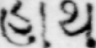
હાથ
